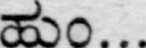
ಹುಂ..
